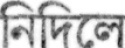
নিদিলে
